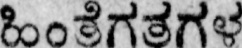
ಹಿಂತೆಗತಗಳ
